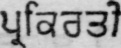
ਪ੍ਰਕਿਰਤੀ
